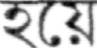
হয়ে
